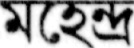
মহেন্দ্র
